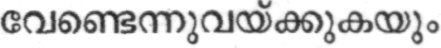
വേണ്ടെന്നുവയ്ക്കുകയും
